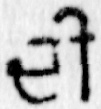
ਦੀ
